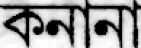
কনানা
